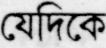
যেদিকে
